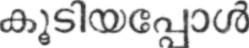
കൂടിയപ്പോള്‍
